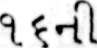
૧૬ની
